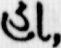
હા,
